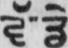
ਵੱਡੇ
